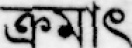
ক্রমাৎ
